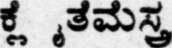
ಕ್ಲೈತೆಮೆಸ್ತ್ರ
